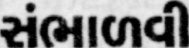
સંભાળવી
